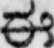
ಈ
